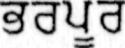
ਭਰਪੂਰ
